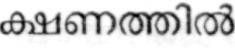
ക്ഷണത്തില്‍
